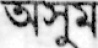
অসুম
